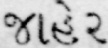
જાહેર
